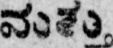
ಮತ್ತು
